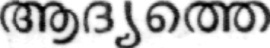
ആദ്യത്തെ
